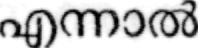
എന്നാല്‍
